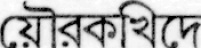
য়ৌরকখিদে
